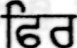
ਫਿਰ
